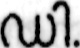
ഡി.
